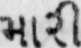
મારી
